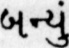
બન્યું
